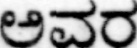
ಅವರ
